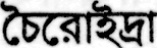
চৈরোইদ্রা
